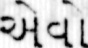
એવો
